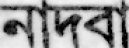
নাদবা
